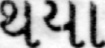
થયા
